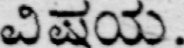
ವಿಷಯ.
